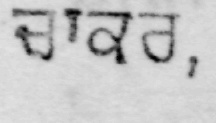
ਚਾਕਰ,
